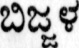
ಬಿಜ್ಜಳ
